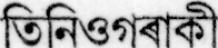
তিনিওগৰাকী
